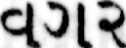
વગર
